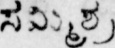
ಸಮ್ಮಿಶ್ರ
